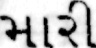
મારી
